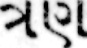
ત્રણ
